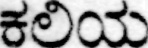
ಕಲಿಯ
